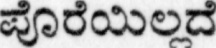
ಪೊರೆಯಿಲ್ಲದೆ
